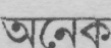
অনেক
